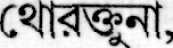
থোরক্তুনা,
